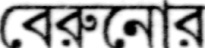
বেরুনোর
